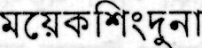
ময়েকশিংদুনা
